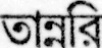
তান্নরি
